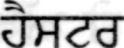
ਹੈਸਟਰ
